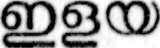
ഇളയ
